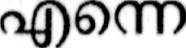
എന്നെ
